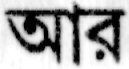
আর
